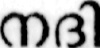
നദി
